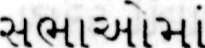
સભાઓમાં
